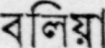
বলিয়া
